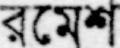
রমেশ
